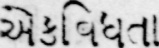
એકવિધતા
